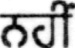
ਨਹੀਂ
